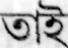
তাই
